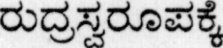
ರುದ್ರಸ್ವರೂಪಕ್ಕೆ
